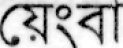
য়েংবা
